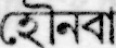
হৌনবা
